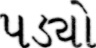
પડ્યો
